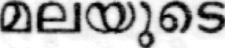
മലയുടെ
